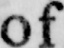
of
